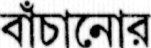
বাঁচানোর
